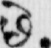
છે.
